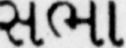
સભા
